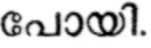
പോയി.
